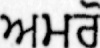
ਅਮਰੋ
